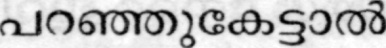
പറഞ്ഞുകേട്ടാല്‍
